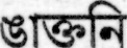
ঙাক্তনি
